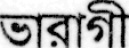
ভারাগী
